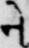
ને
